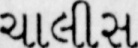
ચાલીસ
